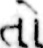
તો
